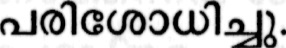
പരിശോധിച്ചു.
